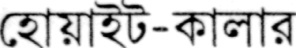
হোয়াইট-কালার
